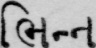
ભિન્ન
